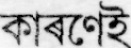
কাৰণেই
